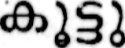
കൂട്ടു
